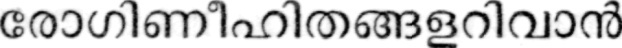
രോഗിണീഹിതങ്ങളറിവാന്‍
